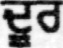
ਦੂਰ
